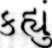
કહ્યું
